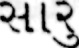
સારુ
